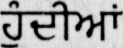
ਹੁੰਦੀਆਂ
